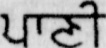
ਪਾਣੀ
